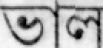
ভাল
